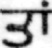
ਤਾਂ
